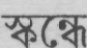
স্কন্ধে
